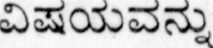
ವಿಷಯವನ್ನು
